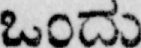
ಒಂದು
